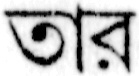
তার
